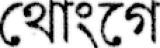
থোংগে
